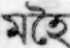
মহৈ
